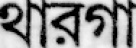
থারগা
